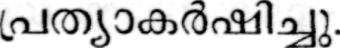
പ്രത്യാകര്‍ഷിച്ചു.
